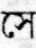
সে
